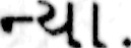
ન્યા.
